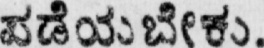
ಪಡೆಯಬೇಕು.
